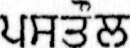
ਪਸਤੌਲ
